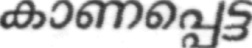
കാണപ്പെട്ട
